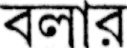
বলার
